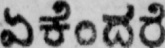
ಏಕೆಂದರೆ
